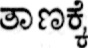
ತಾಣಕ್ಕೆ
